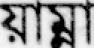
য়াম্না
